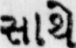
સાથે
